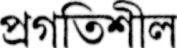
প্রগতিশীল
